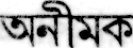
অনীমক
